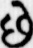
છે
